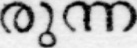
രുന്ന
